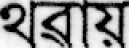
থৱায়
